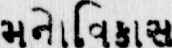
મનોવિકાસ
